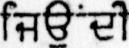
ਜਿਉਂਦੀ
